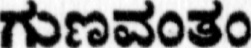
ಗುಣವಂತಂ
